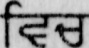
ਵਿਚ
